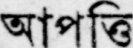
আপত্তি
